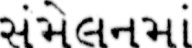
સંમેલનમાં
